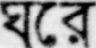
ঘরে
